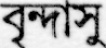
বৃন্দাসু
